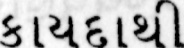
કાયદાથી
